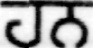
ਹਨ
